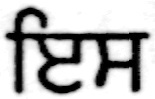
ਇਸ
